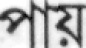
পায়
